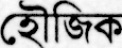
হৌজিক
